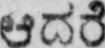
ಆದರೆ
